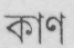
কাণ
